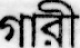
গারী
